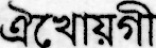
ঐখোয়গী
